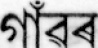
গাঁৱৰ
